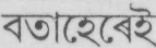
বতাহেৰেই
